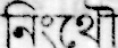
নিংথৌ
